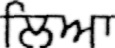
ਲਿਆ
